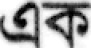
এক
